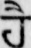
ਹੈ
